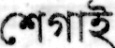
শেগাই
